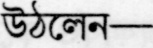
উঠলেন–
